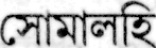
সোমালহি
